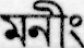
মনীং
